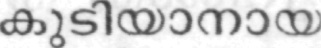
കുടിയാനായ
